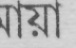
মায়া
